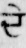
ਦੇ
